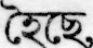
হৈছে,
